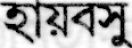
হায়বসু
